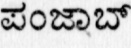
ಪಂಜಾಬ್
